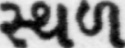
સ્થળ
